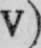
v)
